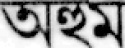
অহুম
